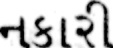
નકારી
